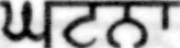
ਘਟਨਾ
